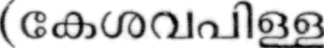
(കേശവപിള്ള
